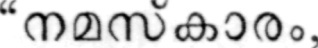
"നമസ്കാരം,
